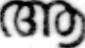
ആ
